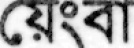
য়েংবা
